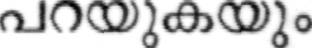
പറയുകയും
